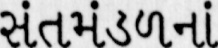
સંતમંડળનાં
